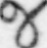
જ
